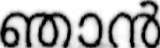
ഞാന്‍
